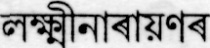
লক্ষ্মীনাৰায়ণৰ
